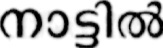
നാട്ടില്‍
